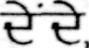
ਦੇਂਦੇ,
